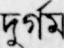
দুর্গম
